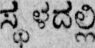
ಸ್ಥಳದಲ್ಲಿ
